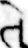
તે
